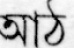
আঠ
